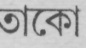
তাকো
